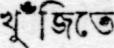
খুঁজিতে
